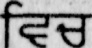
ਵਿਚ
